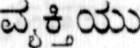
ವ್ಯಕ್ತಿಯು
